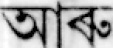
আৰু
